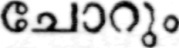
ചോറും
